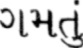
ગમતું
